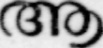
ആ
